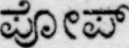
ಪೋಪ್
